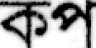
কপ
